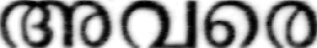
അവരെ
